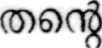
തന്റെ
